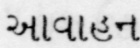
આવાહન
